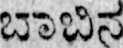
ಬಾಬಿನ
